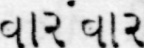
વારંવાર
